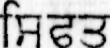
ਸਿਫਤ
